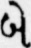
બે
